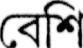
বেশি
